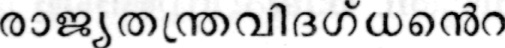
രാജ്യതന്ത്രവിദഗ്ധന്റെ
